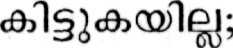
കിട്ടുകയില്ല;
